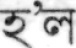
হ'ল
